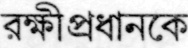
রক্ষীপ্রধানকে
